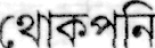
থোকপনি
